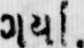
ગયાં.
